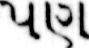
પણ
